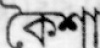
কৈশা
